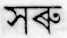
সৰু
